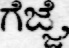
ಗೆಜ್ಜೆ,
